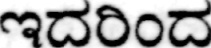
ಇದರಿಂದ
